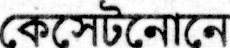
কেসেটনোনে
